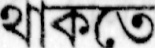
থাকতে
